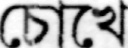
চোখে
